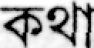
কথা
